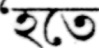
‘হতে
